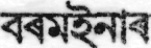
বৰমইনাৰ
